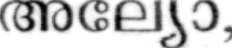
അല്യോ,
